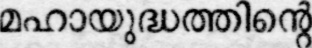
മഹായുദ്ധത്തിന്റെ
